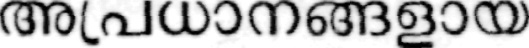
അപ്രധാനങ്ങളായ
